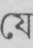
যে
